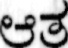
ಆತ
